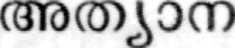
അത്യാന
